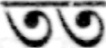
তত
